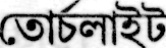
তোর্চলাইট
